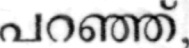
പറഞ്ഞ്,
